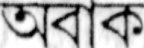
অবাক
